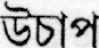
উচাপ
